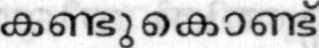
കണ്ടുകൊണ്ട്
